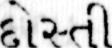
દોસ્તી
